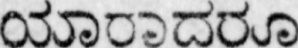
ಯಾರಾದರೂ
